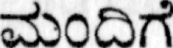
ಮಂದಿಗೆ
